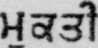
ਮੁਕਤੀ
